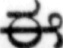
ಈ
